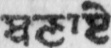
ਬਣਾਏ
